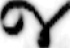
જ
